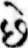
છે
